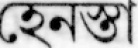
হেনস্তা
